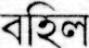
বহিল
